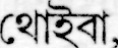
থোইবা,
